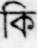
কি
